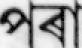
পৰা
